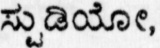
ಸ್ಟುಡಿಯೋ,
